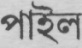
পাইল
